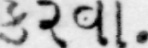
કરવા.
